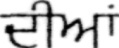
ਦੀਆਂ
